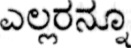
ಎಲ್ಲರನ್ನೂ
